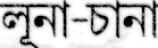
লূনা-চানা
